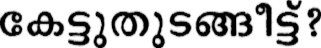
കേട്ടുതുടങ്ങീട്ട്?
